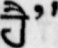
ਹੈ''
